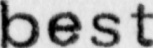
best
